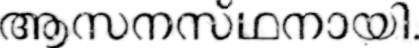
ആസനസ്ഥനായി.
